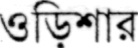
ওড়িশার
